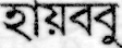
হায়ববু
